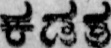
ಕಡತ
